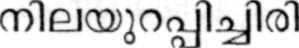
നിലയുറപ്പിച്ചിരി
